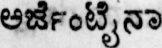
ಅರ್ಜೆಂಟೈನಾ
